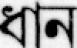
ধান
